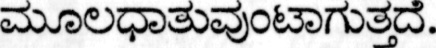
ಮೂಲಧಾತುವುಂಟಾಗುತ್ತದೆ.
